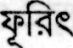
ফূরিৎ
